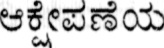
ಆಕ್ಷೇಪಣೆಯ
